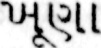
ખૂણા
